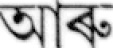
আৰু
